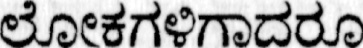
ಲೋಕಗಳಿಗಾದರೂ
